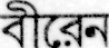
বীরেন
